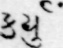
કર્યું
